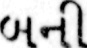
બની
